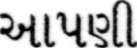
આપણી
